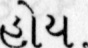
હોય.
